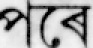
পৰে
